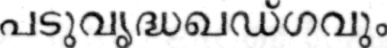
പടുവൃദ്ധഖഡ്ഗവും
